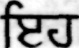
ਇਹ
